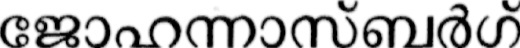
ജോഹന്നാസ്ബര്‍ഗ്
